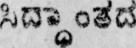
ಸಿದ್ದಾಂತದ
